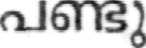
പണ്ടു
